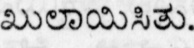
ಖುಲಾಯಿಸಿತು.
